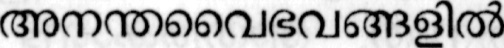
അനന്തവൈഭവങ്ങളില്‍
